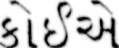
કોઈએ
